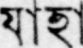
যাহা
